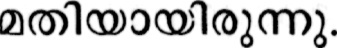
മതിയായിരുന്നു.
